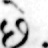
છે.
